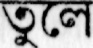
তুলে
